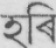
হৰি
